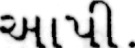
આપી.
